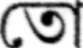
তো
